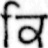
ਕਿ
